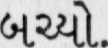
બચ્યો.
